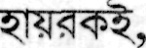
হায়রকই,
